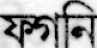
ফগনি
